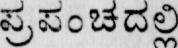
ಪ್ರಪಂಚದಲ್ಲಿ
